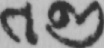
તજી
